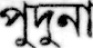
পুদুনা
